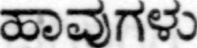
ಹಾವುಗಳು
